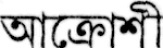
আক্রোশী
